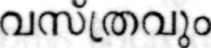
വസ്ത്രവും
